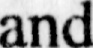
and
